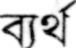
ব্যর্থ
